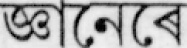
জ্ঞানেৰে
